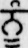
ਨੂੰ
